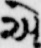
એ
